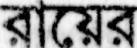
রায়ের
